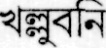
খল্লুবনি
